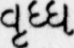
વૃધ્ધ
